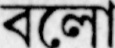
বলো
